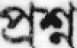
প্ৰশ্ন
